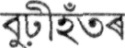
বুঢ়ীহঁতৰ
